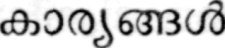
കാര്യങ്ങള്‍
